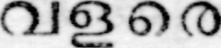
വളരെ
